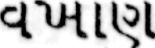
વખાણ
